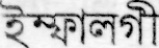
ইম্ফালগী
